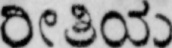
ರೀತಿಯ
